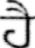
ਹੈ
